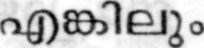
എങ്കിലും
